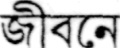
জীবনে
